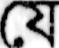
যে
